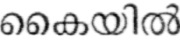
കൈയില്‍
